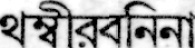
থম্বীরবনিনা
